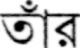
তাঁর
